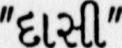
"દાસી"
